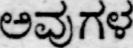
ಅವುಗಳ
